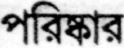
পরিষ্কার
